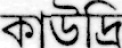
কাউদ্রি
